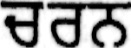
ਚਰਨ
